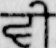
ਵੀ
